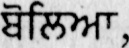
ਬੋਲਿਆ,
